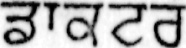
ਡਾਕਟਰ
